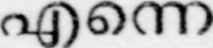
എന്നെ
